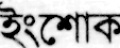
ইংশোক
